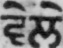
ਵੇਲੇ
